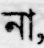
না,
